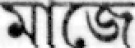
মাজে
